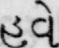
હવે
